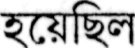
হয়েছিল
